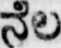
ನೆಲ
